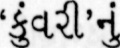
'કુંવરી'નું
